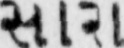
સારા
